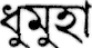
ধুমুহা
